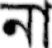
না
